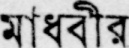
মাধবীর
